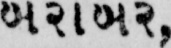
બરાબર,
